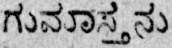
ಗುಮಾಸ್ತನು
